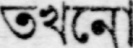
তখনো
